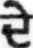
ਦੇ
